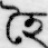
হৈ
